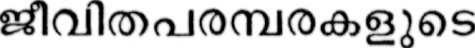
ജീവിതപരമ്പരകളുടെ
